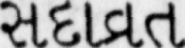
સદાવ્રત
